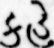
કહે
